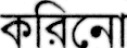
করিনো
